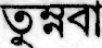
তুম্নবা
